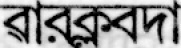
ৱারক্লবদা
